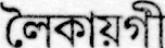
লৈকায়গী
